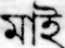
মাই
